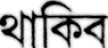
থাকিব
